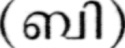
(ബി)
